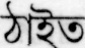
ঠাইত
